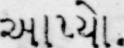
આપ્યો.
